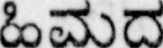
ಹಿಮದ
